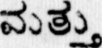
ಮತ್ತು
